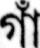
গাঁ
